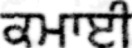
ਕਮਾਈ
